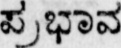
ಪ್ರಭಾವ
